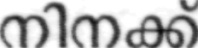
നിനക്ക്
